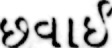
છવાઈ
